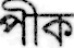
পীক
